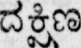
ದಕ್ಷಿಣ
